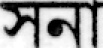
সনা
